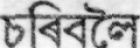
চৰিবলৈ
